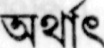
অর্থাৎ
